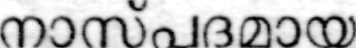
നാസ്പദമായ
